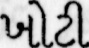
ખોટી
